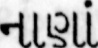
નાણાં
